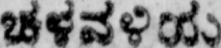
ಚಳವಳಿಯ
